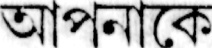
আপনাকে
